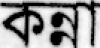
কন্না
